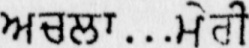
ਅਚਲਾ..........ਮੇਰੀ
